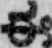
ಈ
